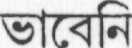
ভাবেনি
